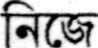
নিজে
